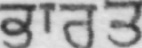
ਭਾਰਤ
